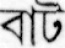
বাট
